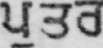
ਪੁਤਰ
